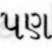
પણ
